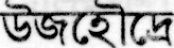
উজহৌদ্রে
